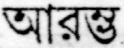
আরম্ভ
